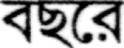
বছরে
